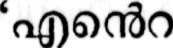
‘എന്റെ
